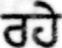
ਰਹੇ
